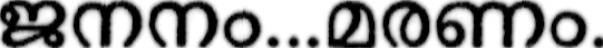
ജനനം...മരണം.
